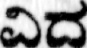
ವಿದ
